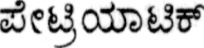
ಪೇಟ್ರಿಯಾಟಿಕ್
